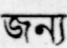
জন্য
